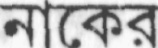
নাকের
